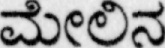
ಮೇಲಿನ
